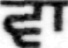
ਵਾ
